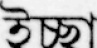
ইচ্ছা
